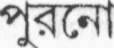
পুরনো
